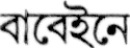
বাবেইনে
